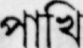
পাখি
